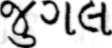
જુગલ
